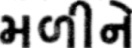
મળીને
